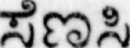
ಸೆಣಸಿ
